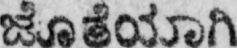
ಜೊತೆಯಾಗಿ
